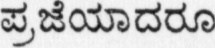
ಪ್ರಜೆಯಾದರೂ
